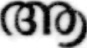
ആ
